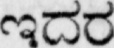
ಇದರ
